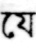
যে
